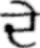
ਦੇ
